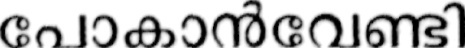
പോകാന്‍വേണ്ടി
